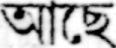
আছে
